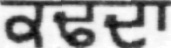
ਕਢਦਾ
